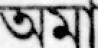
অমা
